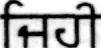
ਜਿਹੀ
